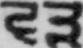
ਵੜ
